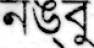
নঙবু
